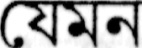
যেমন
